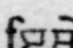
ਇਥੇ
